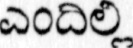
ಎಂದಿಲ್ಲಿ
